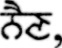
ਨੈਣ,
